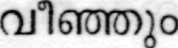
വീഞ്ഞും
